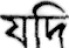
যদি
